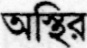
অস্থির
